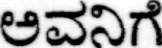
ಅವನಿಗೆ
